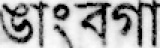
ঙাংবগা
